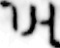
ખ
